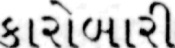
કારોબારી
